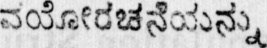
ವಯೋರಚನೆಯನ್ನು
